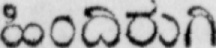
ಹಿಂದಿರುಗಿ
